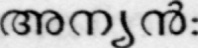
അന്യന്‍:
